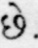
છે.
